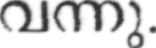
വന്നു.
